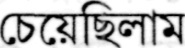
চেয়েছিলাম
